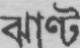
ঝাণ্ট
